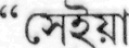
"সেইয়া
